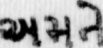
અમને
